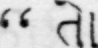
"તો
